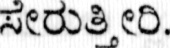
ಸೇರುತ್ತೀರಿ.
